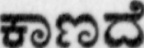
ಕಾಣದೆ
